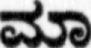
ಮಾ
